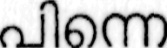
പിന്നെ
